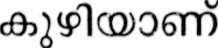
കുഴിയാണ്
